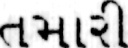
તમારી
